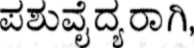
ಪಶುವೈದ್ಯರಾಗಿ,
